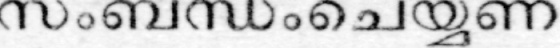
സംബന്ധംചെയ്യണ
